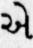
એ
